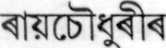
ৰায়চৌধুৰীৰ
